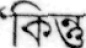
'কিন্তু
